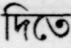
দিতে
